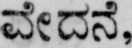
ವೇದನೆ,
